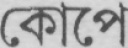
কোপে
